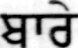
ਬਾਰੇ
